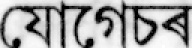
যোগেচৰ
